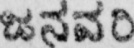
ಜನವರಿ
